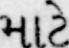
માટે
